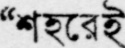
‘‘শহরেই
